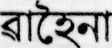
ৱাহৈনা
